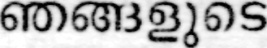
ഞങ്ങളുടെ
